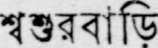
শ্বশুরবাড়ি
